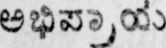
ಅಭಿಪ್ರಾಯ
